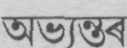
অভ্যন্তৰ
